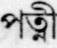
পত্নী
